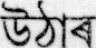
উঠাৰ
